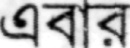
এবার
